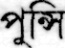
পুন্সি
